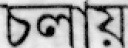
চলায়
